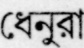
ধেনুরা
